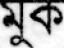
মুক
